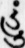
હું
